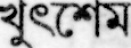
খুৎশেম
